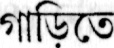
গাড়িতে
